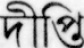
দীপ্তি
